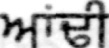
ਆਂਢੀ
